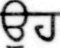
ਉਹ
